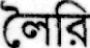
লৈরি
